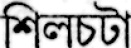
শিলচটা
